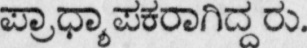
ಪ್ರಾಧ್ಯಾಪಕರಾಗಿದ್ದರು.
